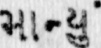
માન્યું
